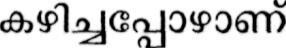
കഴിച്ചപ്പോഴാണ്
